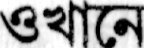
ওখানে
